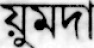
য়ুমদা
